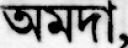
অমদা,
